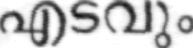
എടവും
